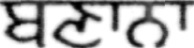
ਬਣਾਨਾ
